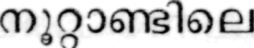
നൂറ്റാണ്ടിലെ
